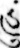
હું
